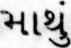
માથું
